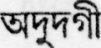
অদুদগী
